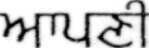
ਆਪਣੀ
